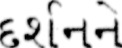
દર્શનને
